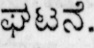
ಘಟನೆ.
